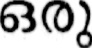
ഒരു
